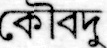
কৌবদু
